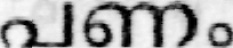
പണം
